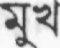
মুখ
